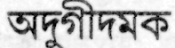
অদুগীদমক
